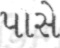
પાસે
